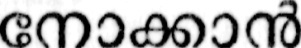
നോക്കാന്‍
